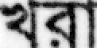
খরা
